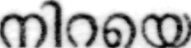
നിറയെ
